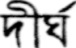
দীর্ঘ
